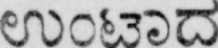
ಉಂಟಾದ
